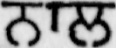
ਨਾਲ
